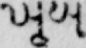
ખૂબ
